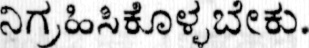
ನಿಗ್ರಹಿಸಿಕೊಳ್ಳಬೇಕು.
